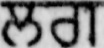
ਲਗ
